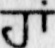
ਹਾਂ
